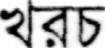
খরচ
